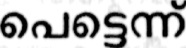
പെട്ടെന്ന്
